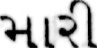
મારી
